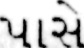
પાસે
